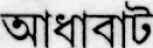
আধাবাট
